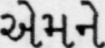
એમને
